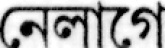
নেলাগে
